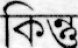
কিন্তু
